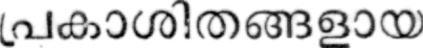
പ്രകാശിതങ്ങളായ
